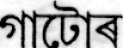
গাটোৰ
